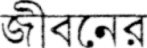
জীবনের
